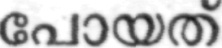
പോയത്
